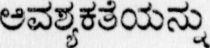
ಅವಶ್ಯಕತೆಯನ್ನು
